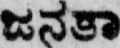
ಜನತಾ
